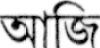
আজি
